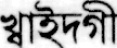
খ্বাইদগী
